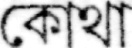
কোথা
